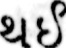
થઈ
